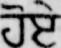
ਹੋਏ
